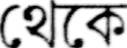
থেকে
